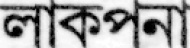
লাকপনা
